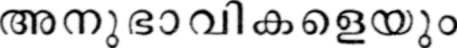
അനുഭാവികളെയും
